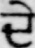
ਦੇ
